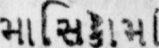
માસિકોમાં
